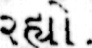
રહ્યો.
